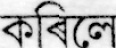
কৰিলে
